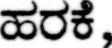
ಹರಕೆ,
